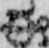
ಈ
